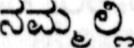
ನಮ್ಮಲ್ಲಿ
